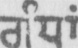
ਗੰਧਾਂ
